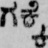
ಗಕ್ಕೆ
